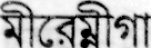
মীরেম্নীগা
